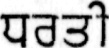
ਧਰਤੀ
